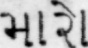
મારો
